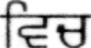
ਵਿਚ
